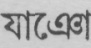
যাঞো
